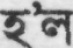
হ'ল
